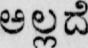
ಅಲ್ಲದೆ
